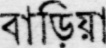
বাড়িয়া
